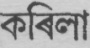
কৰিলা
